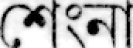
শেংনা
